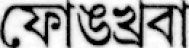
ফোঙখ্রবা
